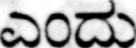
ಎಂದು
